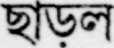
ছাড়ল
